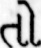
તો
